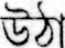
উঠা
